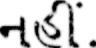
નહીં.
